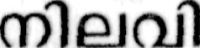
നിലവി
